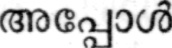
അപ്പോള്‍
